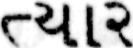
ત્યાર
